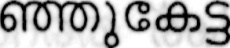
ഞ്ഞുകേട്ട
